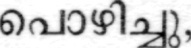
പൊഴിച്ചു,
